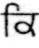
ਕਿ
